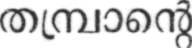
തമ്പ്രാന്റെ
